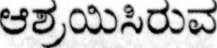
ಆಶ್ರಯಿಸಿರುವ
